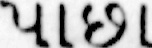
પાછા
